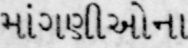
માંગણીઓના
